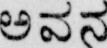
ಅವನ
